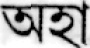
অহা
